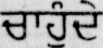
ਚਾਹੁੰਦੇ
